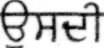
ਉਸਦੀ
